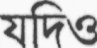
যদিও
